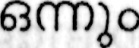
ഒന്നും
